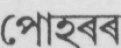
পোহৰৰ
